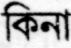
কিনা
